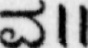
ವ||
